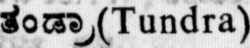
ತಂಡ್ರಾ(Tundra)
